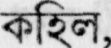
কহিল,
